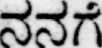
ನನಗೆ
